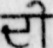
ਦੀ
